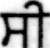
ਸੀ
